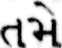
તમે
